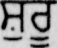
ਸ਼ੁਰੂ
